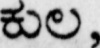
ಕುಲ,
